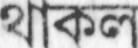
থাকল
